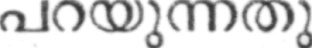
പറയുന്നതു
